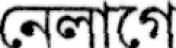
নেলাগে
